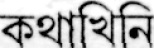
কথাখিনি
